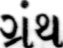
ગ્રંથ
